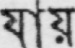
যায়
